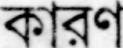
কারণ
